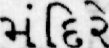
મંદિરે
